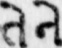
તેને
